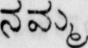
ನಮ್ಮ
